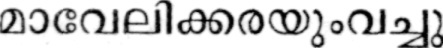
മാവേലിക്കരയുംവച്ചു
